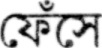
ফেঁসে
